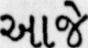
આજે
